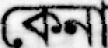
কেনা
